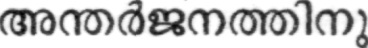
അന്തര്‍ജനത്തിനു
